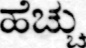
ಹೆಚ್ಚು
